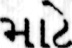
માટે
